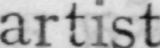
artist
